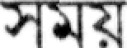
সময়
